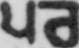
ਪਰ
